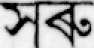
সৰু
